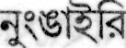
নুংঙাইরি
